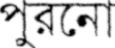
পুরনো
